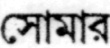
সোমার
